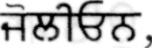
ਜੋਲੀਓਨ,
